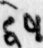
દ્વેષ
